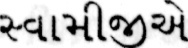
સ્વામીજીએ
